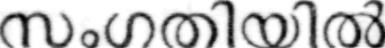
സംഗതിയില്‍
